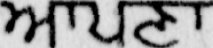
ਆਪਣਾ
